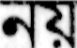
নয়
